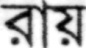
রায়
